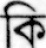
কি
